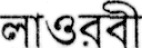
লাওরবী
